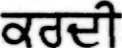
ਕਰਦੀ
